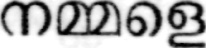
നമ്മളെ
